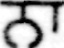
ਨਾ
